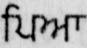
ਪਿਆ
